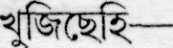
খুজিছেহি-
